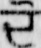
ਦੋ
